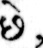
છે,
